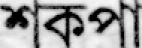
শকপবা
